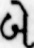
બે
